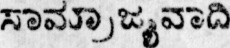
ಸಾಮ್ರಾಜ್ಯವಾದಿ
